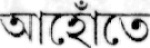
আহোঁতে
